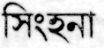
সিংহনা
